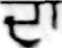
ਦਾ
